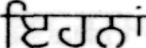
ਇਹਨਾਂ
